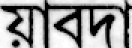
য়াবদা
